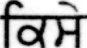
ਕਿਸੇ
